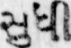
સુધી
